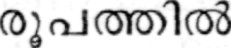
രൂപത്തില്‍
